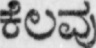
ಕೆಲವು
